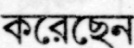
করেছেন
